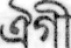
ঐগী
